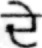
ਦੇ
